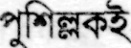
পুশিল্লকই
